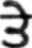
ਤੇ
